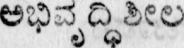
ಅಭಿವೃದ್ಧಿಶೀಲ
